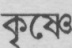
কৃষ্ণে
